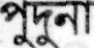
পুদুনা
